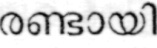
രണ്ടായി
